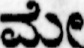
ಮೇ
